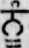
ਨੂੰ
